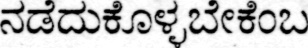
ನಡೆದುಕೊಳ್ಳಬೇಕೆಂಬ
